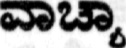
ವಾಚ್ಯಾ
